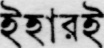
ইহারই
